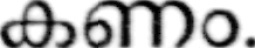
കണം.
